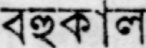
বহুকাল
